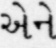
એને
